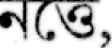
নত্তে,
